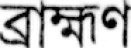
ব্রাহ্মণ
